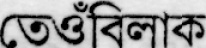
তেওঁবিলাক
